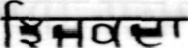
ਝਿਜਕਦਾ
